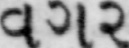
વગર
